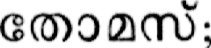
തോമസ്;
